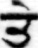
ਤੇ
